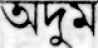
অদুম
